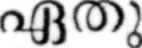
ഏതു
